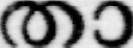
താ
